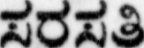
ಸರಸತಿ
